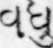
વધું
